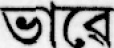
ভাৱে
